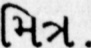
મિત્ર.
